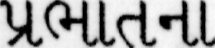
પ્રભાતના
